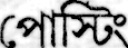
পোস্টিং
